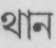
থান
